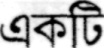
একটি
